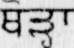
ਥੋੜ੍ਹਾ
